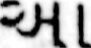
'આ
